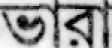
ভারা
